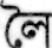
লৈ
